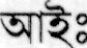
আইঃ
